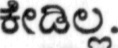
ಕೇಡಿಲ್ಲ.
